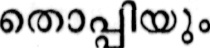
തൊപ്പിയും
